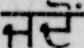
ਜਦੋਂ
